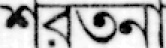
শরতনা
